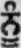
ਨੂੰ
